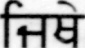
ਜਿਥੇ
